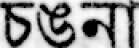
চঙনা
